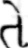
તે
